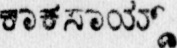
ಕಾಕಸಾಯ್ಡ್
